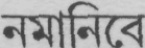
নমানিবে
